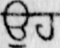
ਉਹ
